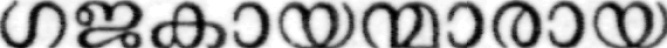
ഗജകായന്മാരായ
